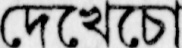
দেখেচো
